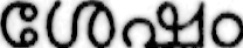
ശേഷം
